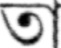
তা
